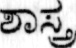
ಶಾಸ್ತ್ರ
